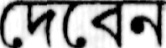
দেবেন
